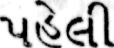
પહેલી
